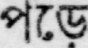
পড়ে
